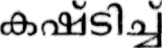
കഷ്ടിച്ച്
